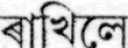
ৰাখিলে
